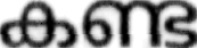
കണ്ട
